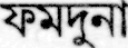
ফমদুনা
